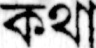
কথা
